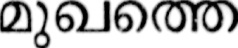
മുഖത്തെ
